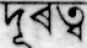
দূৰত্ব
